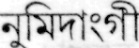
নুমিদাংগী
